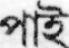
পাই
